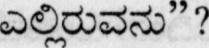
ಎಲ್ಲಿರುವನು”?
